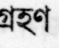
গ্রহণ
